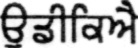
ਉਡੀਕਿਐ
